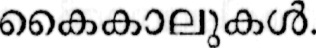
കൈകാലുകള്‍.
